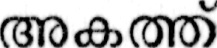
അകത്ത്
